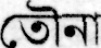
তৌনা
